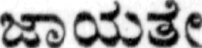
ಜಾಯತೇ
